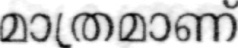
മാത്രമാണ്
